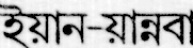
ইয়ান-য়ান্নবা
